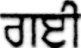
ਗਈ
